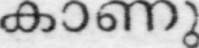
കാണു
